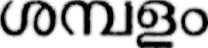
ശമ്പളം
